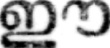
ഈ
